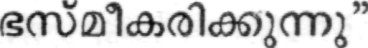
ഭസ്മീകരിക്കുന്നു”
